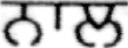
ਨਾਲ
